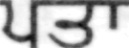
ਪਤਾ
